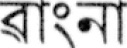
ৱাংনা
